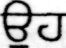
ਉਹ
